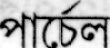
পার্চেল
